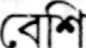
বেশি
